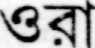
ওরা
